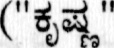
(“ಕೃಷ್ಣ”
